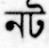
নট
